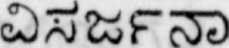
ವಿಸರ್ಜನಾ
